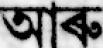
আৰু
